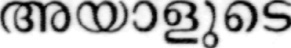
അയാളുടെ
